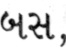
બસ,
